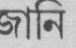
জানি
